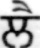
ਲੈ
